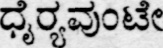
ಧೈರ್ಯವುಂಟೇ
